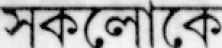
সকলোকে
